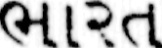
ભારત
